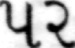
પર
